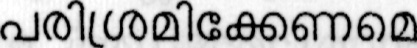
പരിശ്രമിക്കേണമെ
